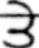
ਤੇ
